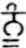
ਨੂੰ
